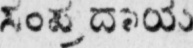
ಸಂಪ್ರದಾಯ
